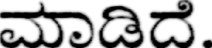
ಮಾಡಿದೆ.
